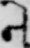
ને
